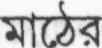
মাঠের
